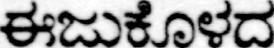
ಈಜುಕೊಳದ
